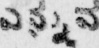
ಎನ್ನುವ
